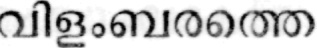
വിളംബരത്തെ
